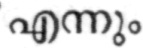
എന്നും
